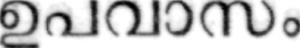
ഉപവാസം
